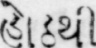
હોઠથી
